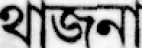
থাজনা
